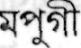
মপুগী
